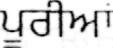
ਪੂਰੀਆਂ
